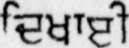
ਦਿਖਾਈ
